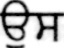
ਉਸ
